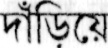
দাঁড়িয়ে
